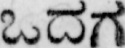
ಒದಗ
